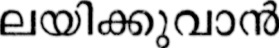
ലയിക്കുവാന്‍
